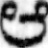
ಆ
